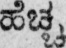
ಹೆಚ್ಚ
